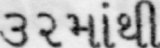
૩૨માંથી
